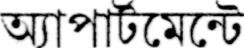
অ্যাপার্টমেন্টে
